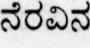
ನೆರವಿನ
